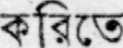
করিতে
